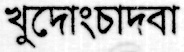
খুদোংচাদবা
